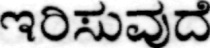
ಇರಿಸುವುದೆ
